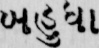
બહુધા
